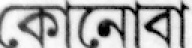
কোনোবা
